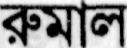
রুমাল
